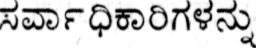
ಸರ್ವಾಧಿಕಾರಿಗಳನ್ನು
